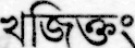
খজিক্তং
